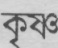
কৃষ্ণ
